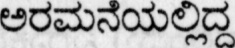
ಅರಮನೆಯಲ್ಲಿದ್ದ
